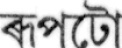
ৰূপটো
